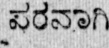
ಪರವಾಗಿ
